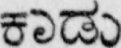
ಕಾಡು
